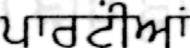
ਪਾਰਟੀਆਂ
